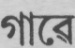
গাৱে
